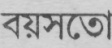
বয়সতো
